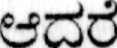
ಆದರೆ
